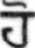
ਹੋ
